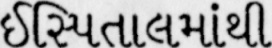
ઈસ્પિતાલમાંથી
